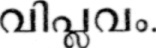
വിപ്ലവം.
